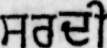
ਸਰਦੀ
